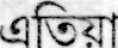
এতিয়া
